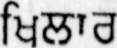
ਖਿਲਾਰ
